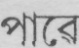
পাৱে
